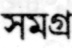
সমগ্র
